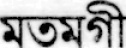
মতমগী
